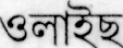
ওলাইছ
